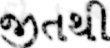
જીતથી
